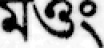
মওং
